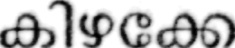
കിഴക്കേ
